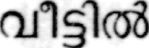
വീട്ടില്‍
